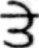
ਤੇ
